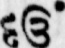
દઉં
